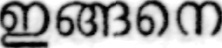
ഇങ്ങനെ
